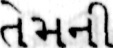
તેમની
